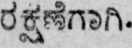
ರಕ್ಷಣೆಗಾಗಿ.
